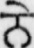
ਨੇ
